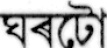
ঘৰটো
